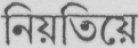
নিয়তিয়ে
